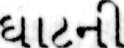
ઘાટની
